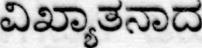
ವಿಖ್ಯಾತನಾದ
